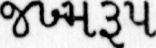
જખ્મરૂપ
